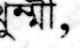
খুম্মী,
